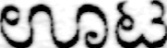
ಊಟ
